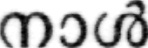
നാള്‍
